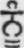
ਨੂੰ
